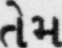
તેમ
